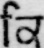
ਕਿ
